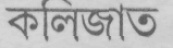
কলিজাত
